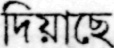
দিয়াছে
